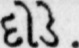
દોડે.
